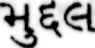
મુદ્દલ
